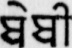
ਬੇਬੀ
